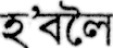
হ'বলৈ
